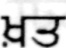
ਖ਼ਤ
